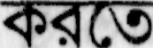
করতে
